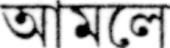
আমলে
